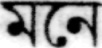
মনে
